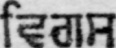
ਵਿਗਸ
